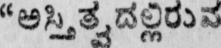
“ಅಸ್ತಿತ್ವದಲ್ಲಿರುವ
